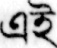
এই
